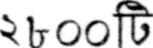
২৮০০টি
